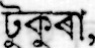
টুকুৰা,
